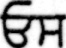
ਓਸ
